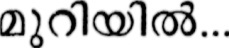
മുറിയില്‍...
